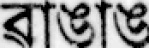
ৱাঙাঙ
